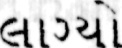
લાગ્યો
